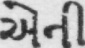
એની
